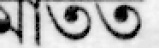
মাতত
